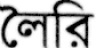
লৈরি
